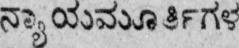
ನ್ಯಾಯಮೂರ್ತಿಗಳ
